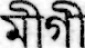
মীগী
